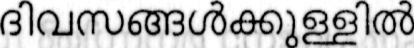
ദിവസങ്ങള്‍ക്കുള്ളില്‍
